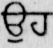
ਉਹ
